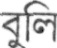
বুলি
